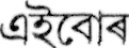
এইবোৰ
